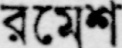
রমেশ
